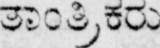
ತಾಂತ್ರಿಕರು
